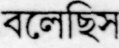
বলেছিস
